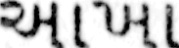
આખા
